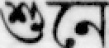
শুনে
